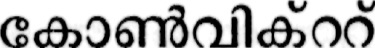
കോണ്‍വിക്ററ്
